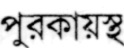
পুরকায়স্থ
